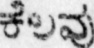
ಕೆಲವು
